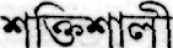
শক্তিশালী
